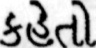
કહેતો
